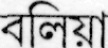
বলিয়া
